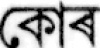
কোৰ
